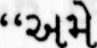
"અમે
